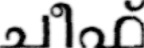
ചീഫ്
